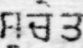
ਸੁਚੇਤ
